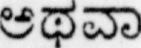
ಅಥವಾ
